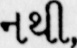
નથી,
